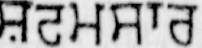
ਸ਼ਰਮਸਾਰ
